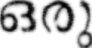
ഒരു
